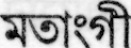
মতাংগী
